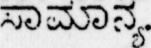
ಸಾಮಾನ್ಯ.
